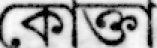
কোক্তা
